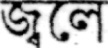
জ্বলে
